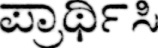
ಪ್ರಾರ್ಥಿಸಿ
